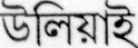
উলিয়াই
